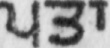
ਪਤਾ
